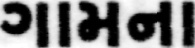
ગામના
